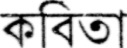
কবিতা
